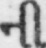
ની
